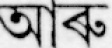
আৰু
